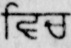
ਵਿਚ
